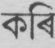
কৰি
